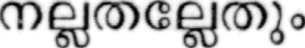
നല്ലതല്ലേതും
